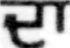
ਦਾ
